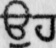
ਉਹ
